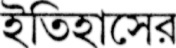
ইতিহাসের
